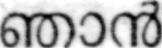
ഞാന്‍
